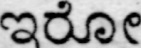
ಇರೋ
